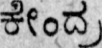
ಕೇಂದ್ರ
